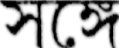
সঙ্গে
